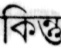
কিন্তু
